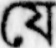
যে
